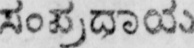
ಸಂಪ್ರದಾಯ
